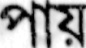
পায়
